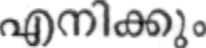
എനിക്കും
